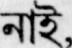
নাই,
